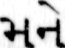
મને
